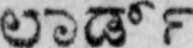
ಲಾರ್ಡ್
